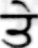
ਤੇ
